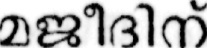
മജീദിന്
